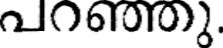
പറഞ്ഞു.
